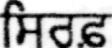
ਸਿਰਫ਼
